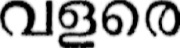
വളരെ
